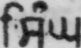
ਸਿੰਘ
